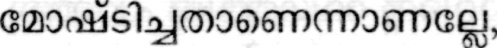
മോഷ്ടിച്ചതാണെന്നാണല്ലേ,
